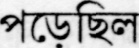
পড়েছিল
